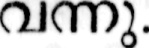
വന്നു.
